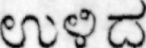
ಉಳಿದ
